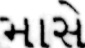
માસે
